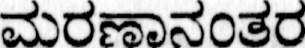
ಮರಣಾನಂತರ
